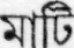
মাটি
